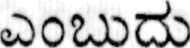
ಎಂಬುದು
